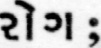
રોગ;
